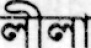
লীলা
